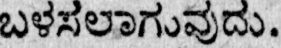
ಬಳಸಲಾಗುವುದು.
